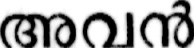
അവന്‍
